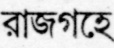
রাজগহে
